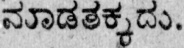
ಮಾಡತಕ್ಕದು.
